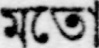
মতো
